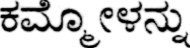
ಕಮ್ಮೋಳನ್ನು
